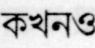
কখনও
